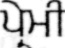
ਪ੍ਰੇਮੀ
